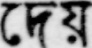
দেয়
